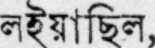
লইয়াছিল,
